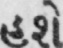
હશે
